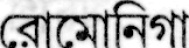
রোমোনিগা
